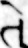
તે
